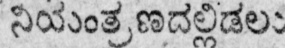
ನಿಯಂತ್ರಣದಲ್ಲಿಡಲು
